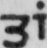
ਤਾਂ
